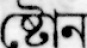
ষ্টোন
